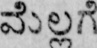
ಮೆಲ್ಲಗೆ
